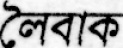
লৈবাক
